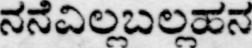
ನನೆವಿಲ್ಲಬಲ್ಲಹನ
